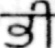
ਭੀ
